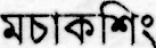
মচাকশিং
